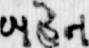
બહેન
